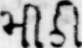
મીઠી
